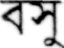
বসু
